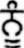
ਨੂੰ
